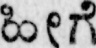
ಹೀಗೆ
